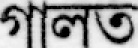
গালত
